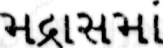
મદ્રાસમાં
